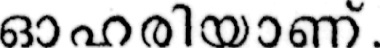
ഓഹരിയാണ്.
